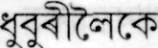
ধুবুৰীলৈকে
